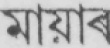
মায়াৰ
